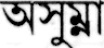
অসুম্না
